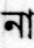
না
